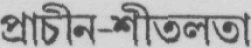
প্ৰাচীন-শীতলতা
